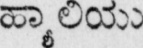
ಹ್ಯಾಲಿಯು
